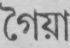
গৈয়া
